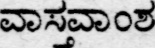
ವಾಸ್ತವಾಂಶ
